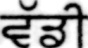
ਵੱਡੀ
